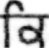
ਕਿ
